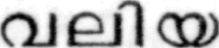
വലിയ
